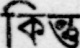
কিন্তু
